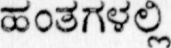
ಹಂತಗಳಲ್ಲಿ
